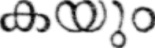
കയും
